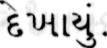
દેખાયું.
